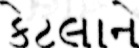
કેટલાને
